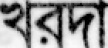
খরদা
